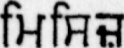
ਮਿਸਿਜ਼
